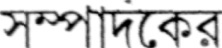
সম্পাদকের
